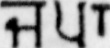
ਜਪਾ
